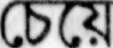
চেয়ে
